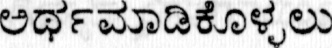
ಅರ್ಥಮಾಡಿಕೊಳ್ಳಲು
